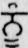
ਨੂੰ
